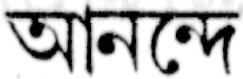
আনন্দে
